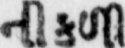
નીકળી
